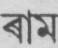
ৰাম
